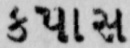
કપાસ
